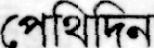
পেথিদিন
